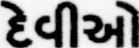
દેવીઓ
